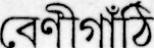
বেণীগাঁঠি
